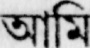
আমি
